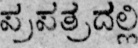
ಪ್ರಪತ್ರದಲ್ಲಿ
